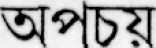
অপচয়
